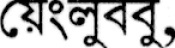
য়েংলুববু,
